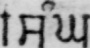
ਸਿੰਘ
